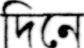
দিনে
